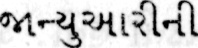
જાન્યુઆરીની
